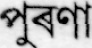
পুৰণা
